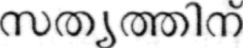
സത്യത്തിന്
